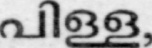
പിള്ള,
